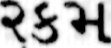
રકમ
